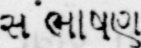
સંભાષણ
